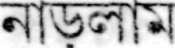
নাড়লাম
